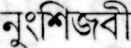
নুংশিজবী
